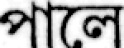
পালে
